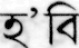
হ'বি
